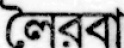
লৈরবা
